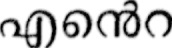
എന്റെ
